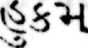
હુકમ
